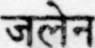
जलेन
